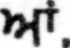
ਆਂ,
